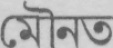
মৌনত
